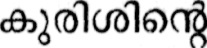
കുരിശിന്റെ
